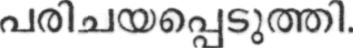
പരിചയപ്പെടുത്തി.
